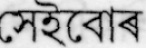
সেইবোৰ
